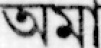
অমা
